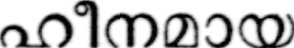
ഹീനമായ
